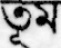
তূম
